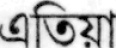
এতিয়া
